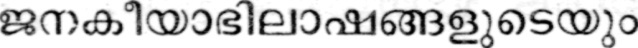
ജനകീയാഭിലാഷങ്ങളുടെയും
